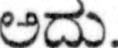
ಅದು.
